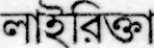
লাইরিক্তা
